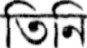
তিনি
